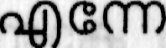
എന്നേ
